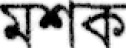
মশক
